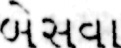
બેસવા
